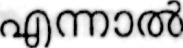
എന്നാല്‍
